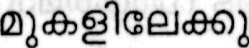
മുകളിലേക്കു
